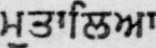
ਮੁਤਾਲਿਆ
